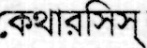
কেথারসিস্
